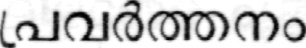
പ്രവര്‍ത്തനം
